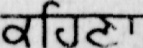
ਕਹਿਣਾ
